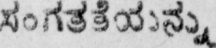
ಸಂಗತತೆಯನ್ನು
